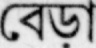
বেড়া
